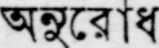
অনুরোধ
